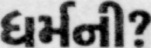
ધર્મની?
